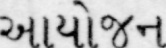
આયોજન
